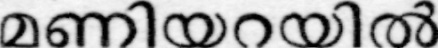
മണിയറയില്‍
